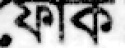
ফোক
